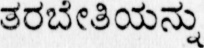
ತರಬೇತಿಯನ್ನು
